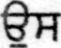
ਉਸ
